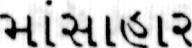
માંસાહાર
